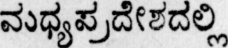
ಮಧ್ಯಪ್ರದೇಶದಲ್ಲಿ
